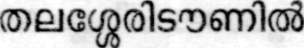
തലശ്ശേരിടൌണില്‍
